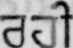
ਰਹੀ
